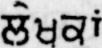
ਲੇਖਕਾਂ
